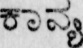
ಕಾವ್ಯ
